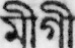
মীগী
